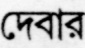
দেবার
